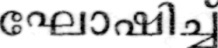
ഘോഷിച്ച്
